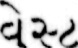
વેસ્ટ
